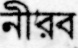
নীরব
